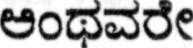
ಅಂಥವರೇ
